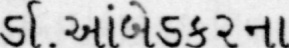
ર્ડા.આંબેડકરના
